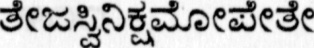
ತೇಜಸ್ವಿನಿಕ್ಷಮೋಪೇತೇ
